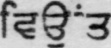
ਵਿਉਂਤ
